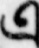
এ
